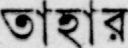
তাহার
